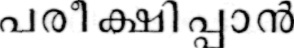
പരീക്ഷിപ്പാന്‍
